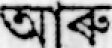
আৰু
